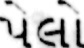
પેલો
